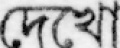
দেখো
